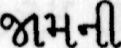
જામની
